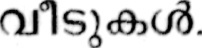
വീടുകള്‍.
